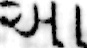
આ
